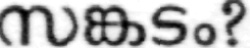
സങ്കടം?
